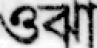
ওঝা
